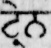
ਟ੍ਰੇਨ
